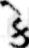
કે
